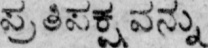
ಪ್ರತಿಪಕ್ಷವನ್ನು
